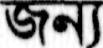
জন্য
